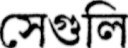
সেগুলি
